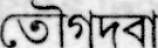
তৌগদবা
